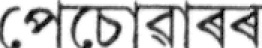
পেচোৱাৰৰ
